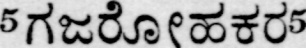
5ಗಜರೋಹಕರ5
